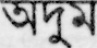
অদুম
